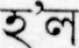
হ'ল
